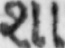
શા
